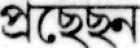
প্রছেছন
